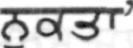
ਨੁਕਤਾ'
